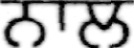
ਨਾਲ
